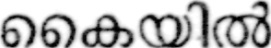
കൈയില്‍
